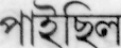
পাইছিল
